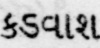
કડવાશ
